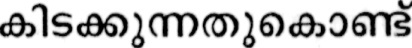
കിടക്കുന്നതുകൊണ്ട്
